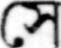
সে
